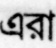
এরা
